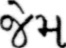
જેમ
